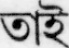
তাই
